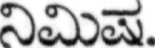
ನಿಮಿಷ.
